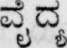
ವೈದ್ಯ
